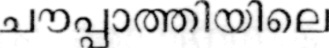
ചൌപ്പാത്തിയിലെ
